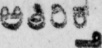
ಅತಿರಿಕ್ತ
